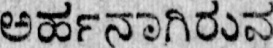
ಅರ್ಹನಾಗಿರುವ
